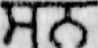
ਸਨ
